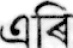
এৰি
